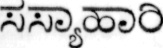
ಸಸ್ಯಾಹಾರಿ
